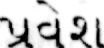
પ્રવેશ
